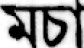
মচা
